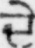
ਦੇ
